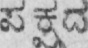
ಪಕ್ಷದ
